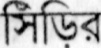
সিঁড়ির
